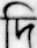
দি
